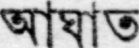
আঘাত
